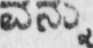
ವನ್ನು
